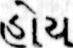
હોય
